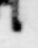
ન
